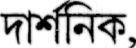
দার্শনিক,
